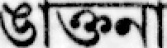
ঙাক্তনা
